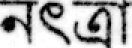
নৎত্রা
